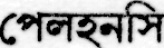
পেলহনসি
